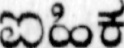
ಐಹಿಕ
